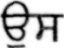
ਉਸ
